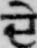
ਦੇ
